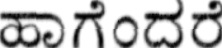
ಹಾಗೆಂದರೆ
